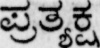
ಪ್ರತ್ಯಕ್ಷ
